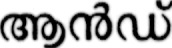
ആന്‍ഡ്
